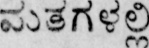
ಮತಗಳಲ್ಲಿ
